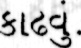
કાઢવું.
